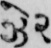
ઝેર
